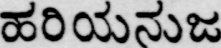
ಹರಿಯನುಜ
